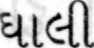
ઘાલી
